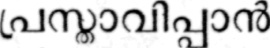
പ്രസ്താവിപ്പാന്‍
